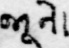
જૂનો
